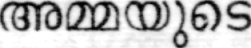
അമ്മയുടെ
